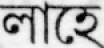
লাহে
